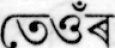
তেওঁৰ
